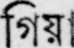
গিয়া
